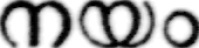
നയം
